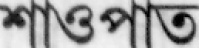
শাওপাত
